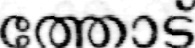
ത്തോട്
